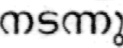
നടന്നു
